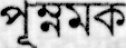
পূম্নমক
